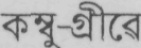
কম্বু-গ্ৰীৱে
